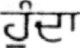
ਹੁੰਦਾ
